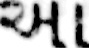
આ
